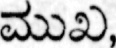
ಮುಖ,
